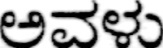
ಅವಳು
